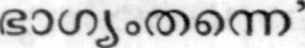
ഭാഗ്യംതന്നെ'
